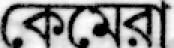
কেমেরা
